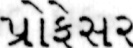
પ્રોફેસર
